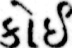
કોઈ
